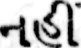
નહીં
